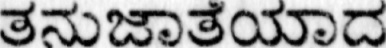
ತನುಜಾತೆಯಾದ
